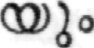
യും
